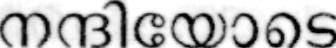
നന്ദിയോടെ
